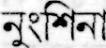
নুংশিনা
